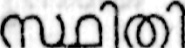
സ്ഥിതി
